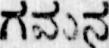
ಗಮನ
